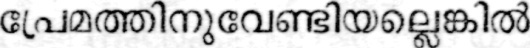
പ്രേമത്തിനുവേണ്ടിയല്ലെങ്കില്‍
